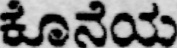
ಕೊನೆಯ
